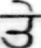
ਤੇ
